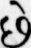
છે
